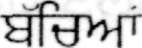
ਬੱਚਿਆਂ
